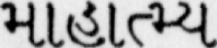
માહાત્મ્ય
